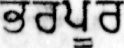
ਭਰਪੂਰ
